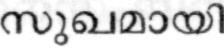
സുഖമായി
